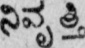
ನಿವೃತ್ತಿ
